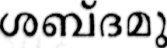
ശബ്ദമു
